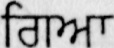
ਗਿਆ
